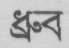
ধ্ৰুব
